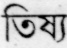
তিষ্য
